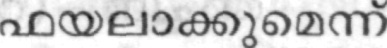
ഫയലാക്കുമെന്ന്
